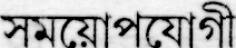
সময়োপযোগী
